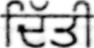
ਦਿੱਤੀ
